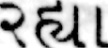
રહ્યા
